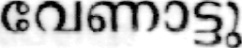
വേണാട്ടു
